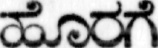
ಹೊರಗೆ
